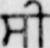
ਸੀ
